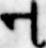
ન
